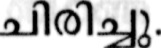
ചിരിച്ചു.
